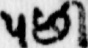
પછી
